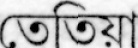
তেতিয়া
